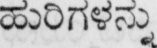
ಹುರಿಗಳನ್ನು
